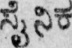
ಸೈನಿಕ
